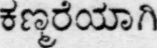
ಕಣ್ಮರೆಯಾಗಿ
